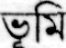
ভূমি
